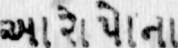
આરોપોના
